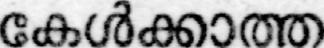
കേള്‍ക്കാത്ത
